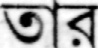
তার
